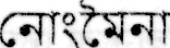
নোংমৈনা
